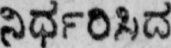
ನಿರ್ಧರಿಸಿದ
